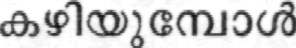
കഴിയുമ്പോള്‍
